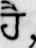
ਹੈ,
